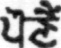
ਪੌਣੈਂ
